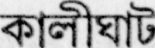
কালীঘাট
